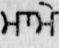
ਮਾਮੇ
